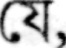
যে,
